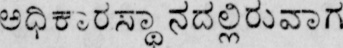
ಅಧಿಕಾರಸ್ಥಾನದಲ್ಲಿರುವಾಗ
